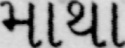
માથા
